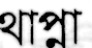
থাপ্না
